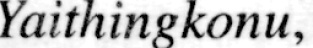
Yaithingkonu,
